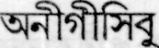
অনীগীসিবু
